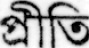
প্রীতি
